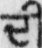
ਦੀ
